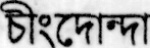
চীংদোন্দা
